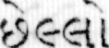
છેલ્લો
